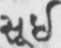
સૂઈ
